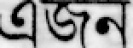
এজন
